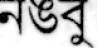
নঙবু
